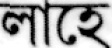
লাহে
